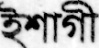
ইশাগী
